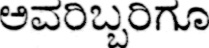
ಅವರಿಬ್ಬರಿಗೂ
